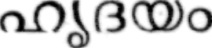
ഹൃദയം
